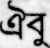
ঐবু
